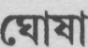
ঘোষা
